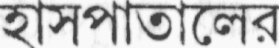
হাসপাতালের
